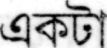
একটা
